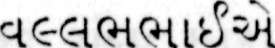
વલ્લભભાઈએ
